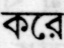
করে
